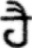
ਹੈ
